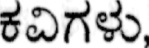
ಕವಿಗಳು,
